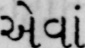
એવાં
